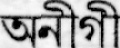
অনীগী
